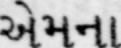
એમના
